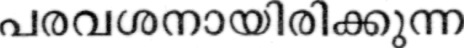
പരവശനായിരിക്കുന്ന
